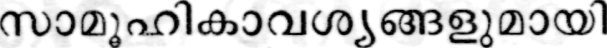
സാമൂഹികാവശ്യങ്ങളുമായി
